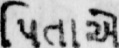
પિતાએ
